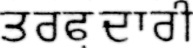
ਤਰਫ਼ਦਾਰੀ
